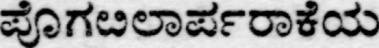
ಪೊಗೞಲಾರ್ಪರಾಕೆಯ
